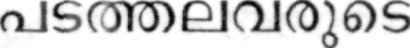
പടത്തലവരുടെ
